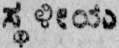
ಸ್ಥಳೀಯ
